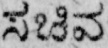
ಸಚಿವ
